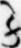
કે
